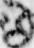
છે
